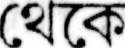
থেকে
